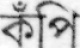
কঁপি
